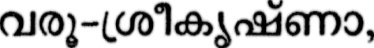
വരൂ-ശ്രീകൃഷ്ണാ,
